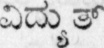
ವಿದ್ಯುತ್
